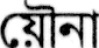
য়ৌনা
